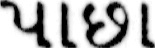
પાછા
